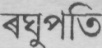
ৰঘুপতি
